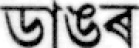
ডাঙৰ
